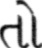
તો
